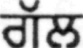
ਗੱਲ
